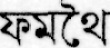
ফমথৈ
